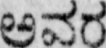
ಅವರ
